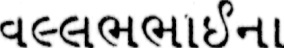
વલ્લભભાઈના
